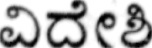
ವಿದೇಶಿ
